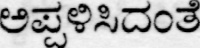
ಅಪ್ಪಳಿಸಿದಂತೆ
